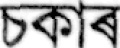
চকাৰ
